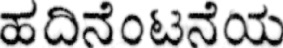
ಹದಿನೆಂಟನೆಯ
